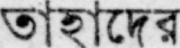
তাহাদের
